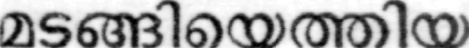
മടങ്ങിയെത്തിയ
